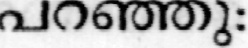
പറഞ്ഞു:
